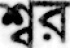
শ্বর
